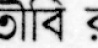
তৌবি
